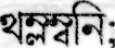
থম্লম্বনি;
